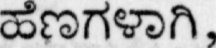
ಹೆಣಗಳಾಗಿ,
